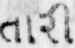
તારી
